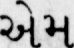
એમ
